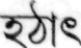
হঠাৎ
